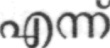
എന്ന്
